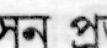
সন প্র
